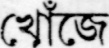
খোঁজে
